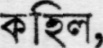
কহিল,
